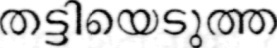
തട്ടിയെടുത്ത
